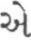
એ
